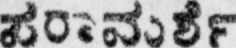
ಪರಾಮರ್ಶೆ
